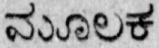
ಮೂಲಕ
